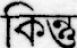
কিন্তু
